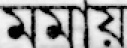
মমায়
